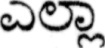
ಎಲ್ಲಾ
